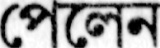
পেলেন
